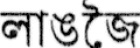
লাঙজৈ
